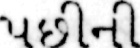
પછીની
